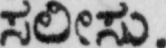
ಸಲೀಸು.
